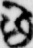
છે
